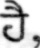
ਹੈ,
